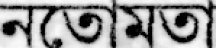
নতোমতা
